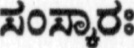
ಸಂಸ್ಕಾರಃ
